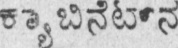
ಕ್ಯಾಬಿನೆಟ್‌ನ
